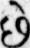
છે
